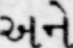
અને
